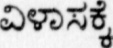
ವಿಳಾಸಕ್ಕೆ
